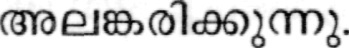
അലങ്കരിക്കുന്നു.
